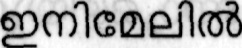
ഇനിമേലില്‍
